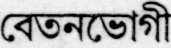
বেতনভোগী
